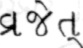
વ્રજેત્
